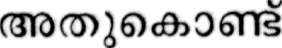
അതുകൊണ്ട്
